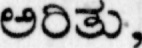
ಅರಿತು,
